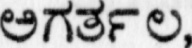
ಅಗರ್ತಲ,
